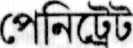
পেনিট্রেট
